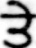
ਤੇ
